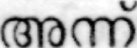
അന്ന്
